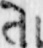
તો
